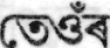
তেওঁৰ
